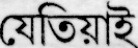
যেতিয়াই
